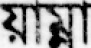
য়াম্না
